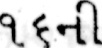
૧૬ની
